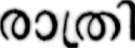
രാത്രി
